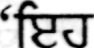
'ਇਹ
